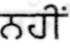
ਨਹੀਂ
